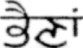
ਭੈਣਾਂ
